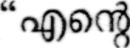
“എന്റെ
